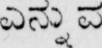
ಎನ್ನುವ
